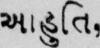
આહુતિ,
